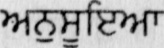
ਅਨੁਸੂਇਆ
